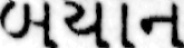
બયાન
